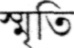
স্মৃতি
